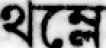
থম্লে
